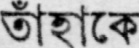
তাঁহাকে
